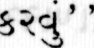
કરવું"
